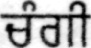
ਚੰਗੀ
